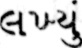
લખ્યું
